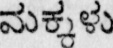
ಮಕ್ಕಳು
